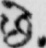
છે.
